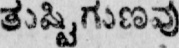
ತುಷ್ಟಿಗುಣವು
